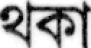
থকা
